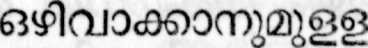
ഒഴിവാക്കാനുമുള്ള
